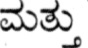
ಮತ್ತು
